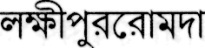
লক্ষীপুররোমদা
